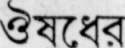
ঔষধের
